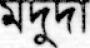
মদুদা
